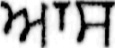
ਆਸ
